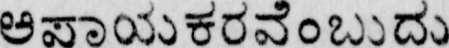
ಅಪಾಯಕರವೆಂಬುದು
